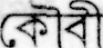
কৌবী
